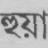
হুয়া
